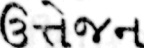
ઉત્તેજન
